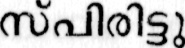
സ്പിരിട്ടു
